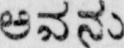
ಅವನು
